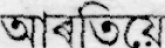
আৰতিয়ে
